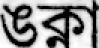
ঙক্না
